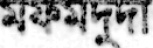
মফমদুদা
